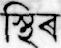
স্থিৰ
